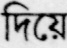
দিয়ে
